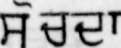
ਸੋਚਦਾ
